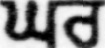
ਘਰ
